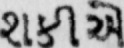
શકીએ
